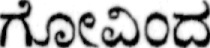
ಗೋವಿಂದ
